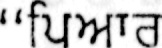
''ਪਿਆਰ
